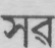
সৱ
